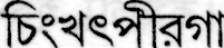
চিংখৎপীরগা
